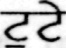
ਟੁਟੇ
